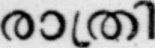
രാത്രി
